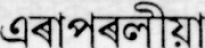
এৰাপৰলীয়া
